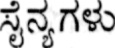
ಸೈನ್ಯಗಳು
